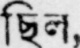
ছিল,
